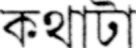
কথাটা
